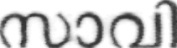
സാവി
